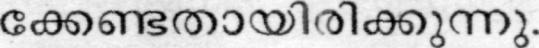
ക്കേണ്ടതായിരിക്കുന്നു.
